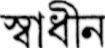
স্বাধীন
